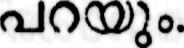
പറയും.
